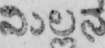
ಮಿಲ್ಲನ
